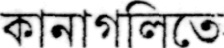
কানাগলিতে
